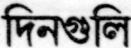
দিনগুলি
